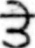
ਤੇ
